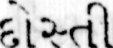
દોસ્તી
